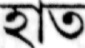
হাত
